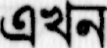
এখন
